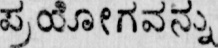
ಪ್ರಯೋಗವನ್ನು
